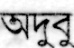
অদুবু
